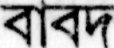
বাবদ
